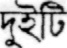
দুইটি
